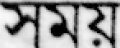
সময়
